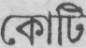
কোটি
